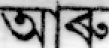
আৰু
